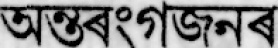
অন্তৰংগজনৰ
